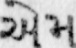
એમ
